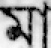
মা
